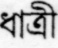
ধাত্রী
